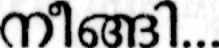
നീങ്ങി...
